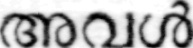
അവള്‍
